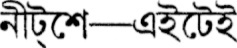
নীট্‌শে-এইটেই
